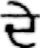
ਦੇ
